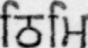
ਠਿਮਿ
